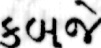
કબજે
